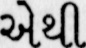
એથી
